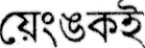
য়েংঙকই
